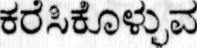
ಕರೆಸಿಕೊಳ್ಳುವ
